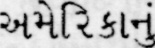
અમેરિકાનું
